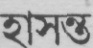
হাসন্ত
